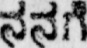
ನನಗೆ
